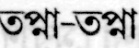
তপ্না-তপ্না
